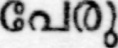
പേരു
